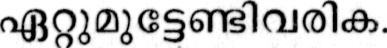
ഏറ്റുമുട്ടേണ്ടിവരിക.
